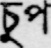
চুপ
